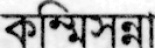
কম্মিসন্না
